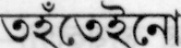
তহঁতেইনো
